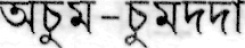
অচুম-চুমদদা
